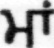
ਮਾਂ
